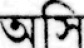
অসি
